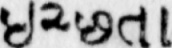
ઇચ્છતા
